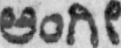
ಅಂಗೀ
